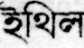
ইথিল
